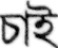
চাই
